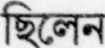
ছিলেন
